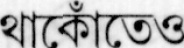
থাকোঁতেও
